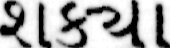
શક્યા
